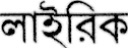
লাইরিক
